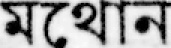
মথোন
